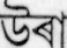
উৰা
